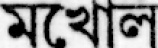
মখোল
